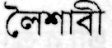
লৈশাবী
